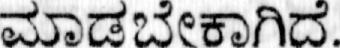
ಮಾಡಬೇಕಾಗಿದೆ.
